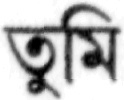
তুমি
